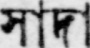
সাদা
